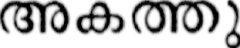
അകത്തു
